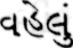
વહેલું
